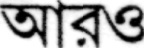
আরও
